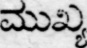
ಮುಖ್ಯ
